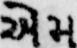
એમ
